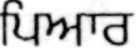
ਪਿਆਰ
